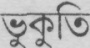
ভুকুতি
